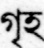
গৃহ
